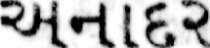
અનાદર
